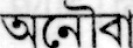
অনৌবা
